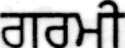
ਗਰਮੀ
